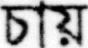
চায়
